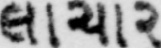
લાચાર
